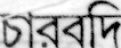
চারবদি
